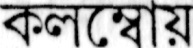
কলম্বোয়
